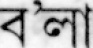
ব'লা
